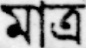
মাত্র
